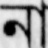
না
